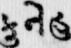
કુનેહ
